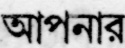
আপনার
